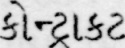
કોન્ટ્રાકટ
